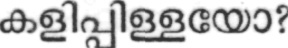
കളിപ്പിള്ളയോ?
